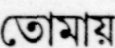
তোমায়
